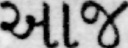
આજ
